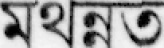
মথন্নত
